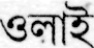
ওলাই
